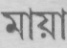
মায়া
